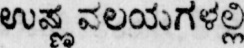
ಉಷ್ಣವಲಯಗಳಲ್ಲಿ
